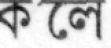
ক'লে
